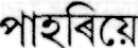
পাহৰিয়ে
